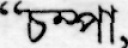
"চম্পা,
